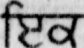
ਇਕ
